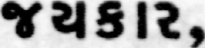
જયકાર,
